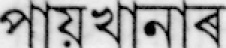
পায়খানাৰ
